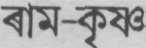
ৰাম-কৃষ্ণ
